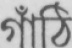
গাঁঠি
